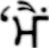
'ਮੈਂ
